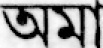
অমা
